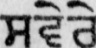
ਸਵੇਰੇ
